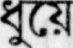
ধুয়ে
